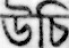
উচি
